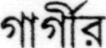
গার্গীর
